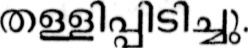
തള്ളിപ്പിടിച്ചു.
